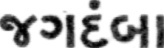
જગદંબા
